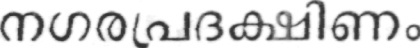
നഗരപ്രദക്ഷിണം
